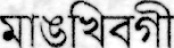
মাঙখিবগী
